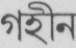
গহীন
